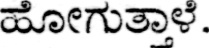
ಹೋಗುತ್ತಾಳೆ.
